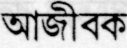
আজীবক
